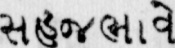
સહજભાવે
